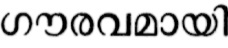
ഗൌരവമായി
